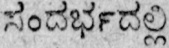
ಸಂದರ್ಭದಲ್ಲಿ
